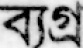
ব্যগ্র
